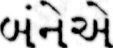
બંનેએ
